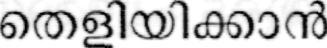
തെളിയിക്കാന്‍
